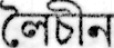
লৈচীন
